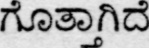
ಗೊತ್ತಾಗಿದೆ
